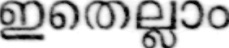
ഇതെല്ലാം
